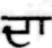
ਦਾ
